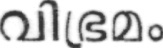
വിഭ്രമം
